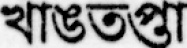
খাঙতপ্তা
